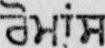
ਰੋਮਾਂਸ
